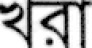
খরা
